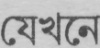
যেখনে
